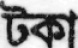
টকা
